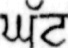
ਘੱਟ
